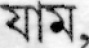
যাম,
